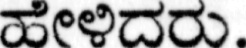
ಹೇಳಿದರು.
